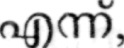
എന്ന്,
